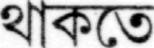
থাকতে
